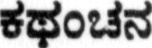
ಕಥ೦ಚನ
